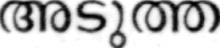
അടുത്ത
